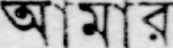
আমার
